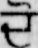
ਦੋ
